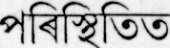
পৰিস্থিতিত
